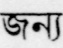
জন্য
